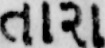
તારા
